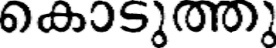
കൊടുത്തു
